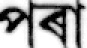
পৰা
